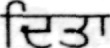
ਦਿਤਾ
